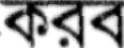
করব
